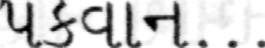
પકવાન...
